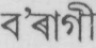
ব'ৰাগী
